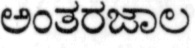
ಅಂತರಜಾಲ
